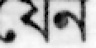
যেন
